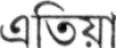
এতিয়া
